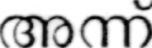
അന്ന്
